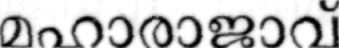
മഹാരാജാവ്
